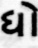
ધો
